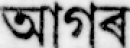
আগৰ
